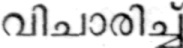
വിചാരിച്ച്
